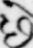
છે
